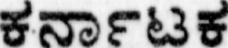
ಕರ್ನಾಟಕ
